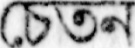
চেতন
